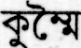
কুম্মৈ
